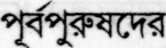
পূর্বপুরুষদের
